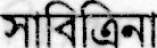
সাবিত্রিনা
